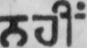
ਨਹੀਂ
